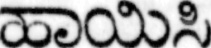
ಹಾಯಿಸಿ
